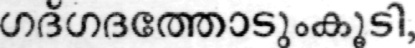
ഗദ്ഗദത്തോടുംകൂടി,
